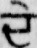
ਦੇ
